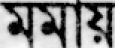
মমায়
